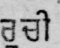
ਰੁਚੀ
